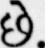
છે.
